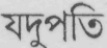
যদুপতি
